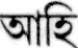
আহি
